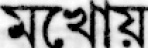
মখোয়
